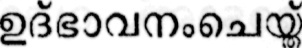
ഉദ്ഭാവനംചെയ്ത്
